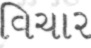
વિચાર
